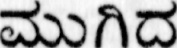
ಮುಗಿದ
